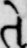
તે
